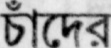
চাঁদের
